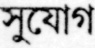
সুযোগ
